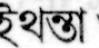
ইথন্তা
